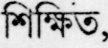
শিক্ষিত,
